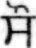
ਸੌ
